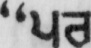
''ਪਰ
